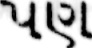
પણ
